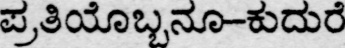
ಪ್ರತಿಯೊಬ್ಬನೂ-ಕುದುರೆ
